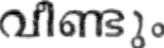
വീണ്ടും
